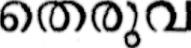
തെരുവ
